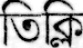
তিক্লি
